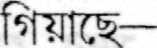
গিয়াছে—
